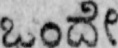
ಒಂದೇ
